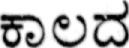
ಕಾಲದ
